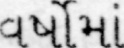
વર્ષોમાં
